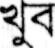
খুব
